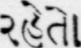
રહેતો
